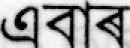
এবাৰ
